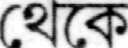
থেকে
